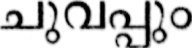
ചുവപ്പും
